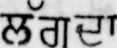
ਲੱਗਦਾ
